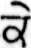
ਕੇ
